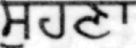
ਸੁਹਣਾ
